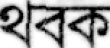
থবক
